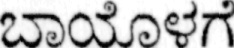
ಬಾಯೊಳಗೆ
